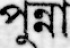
পুন্না
